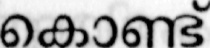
കൊണ്ട്
